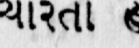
વિચારતા
